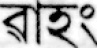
ৱাহং
